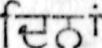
ਦਿਨਾਂ
